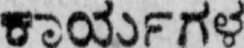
ಕಾರ್ಯಗಳ
